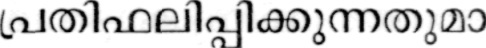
പ്രതിഫലിപ്പിക്കുന്നതുമാ
